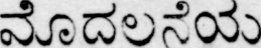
ಮೊದಲನೆಯ
